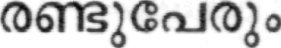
രണ്ടുപേരും
